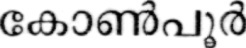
കോണ്‍പൂര്‍
